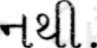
નથી.
